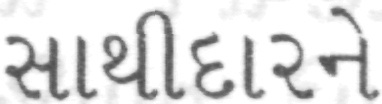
સાથીદારને
